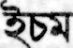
ইচম
